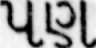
પણ
